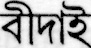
বীদাই
